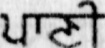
ਪਾਣੀ
